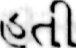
હતી
